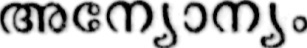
അന്യോന്യം
